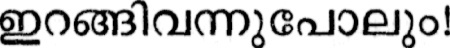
ഇറങ്ങിവന്നുപോലും!
